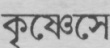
কৃষ্ণেসে
